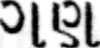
ગણ
